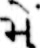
મેં
